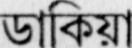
ডাকিয়া
